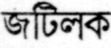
জটিলক
